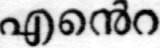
എന്റെ
